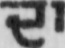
ਦਾ
